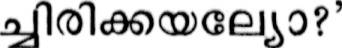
ച്ചിരിക്കയല്യോ?’
